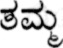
ತಮ್ಮ
